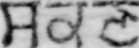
ਸਕਣ
